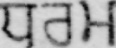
ਧਰਮ
